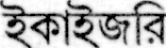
ইকাইজরি
